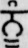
ਨੂੰ
